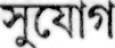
সুযোগ
